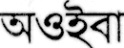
অওইবা
